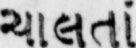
ચાલતાં
